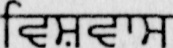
ਵਿਸ਼ਵਾਸ
